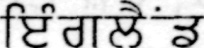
ਇੰਗਲੈਂਡ
